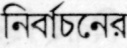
নির্বাচনের
